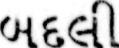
બદલી
